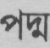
পদ্ম
